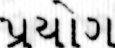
પ્રયોગ
